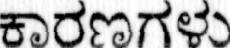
ಕಾರಣಗಳು
